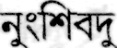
নুংশিবদু
